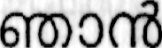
ഞാന്‍
